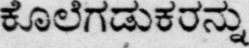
ಕೊಲೆಗಡುಕರನ್ನು
